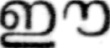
ഈ
